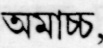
অমাচ্চ,
